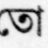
তো
